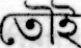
তৌই
